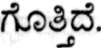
ಗೊತ್ತಿದೆ.
